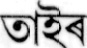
তাইৰ
